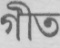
গীত
